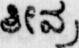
ತೀವ್ರ
